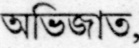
অভিজাত,
